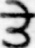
ਤੇ
